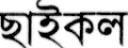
ছাইকল
